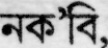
নক'বি,
